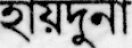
হায়দুনা
